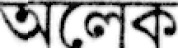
অলেক
